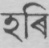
হৰি
